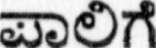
ಪಾಲಿಗೆ
